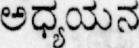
ಅಧ್ಯಯನ
